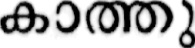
കാത്തു
